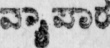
ವ್ಯಾಪಾರ
